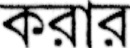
করার
